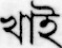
খাই
